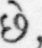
છે,
